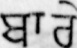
ਬਾਰੇ
